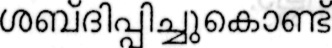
ശബ്ദിപ്പിച്ചുകൊണ്ട്
